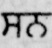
ਸਨ
